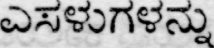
ಎಸಳುಗಳನ್ನು
